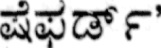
ಷೆಫರ್ಡ್’
